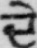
ਦੇ
